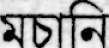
মচানি
